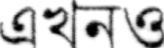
এখনও
